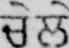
ਚੇਲੇ
